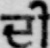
ਦੀ
